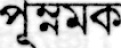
পূম্নমক
